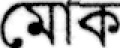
মোক
